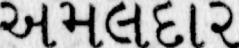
અમલદાર
